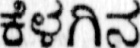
ಕೆಳಗಿನ
